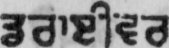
ਡਰਾਈਵਰ
